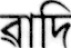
ৱাদি
